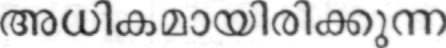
അധികമായിരിക്കുന്ന
